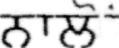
ਨਾਲੋਂ
